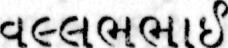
વલ્લભભાઈ
